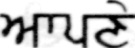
ਆਪਣੇ
